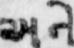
અને
